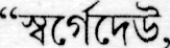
"স্বর্গেদেউ,
